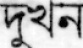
দুখন
